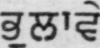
ਭੁਲਾਵੇ
